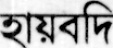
হায়বদি
